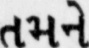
તમને
